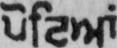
ਪੋਟਿਆਂ
